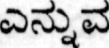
ಎನ್ನುವ
